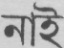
নাই
